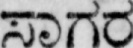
ಸಾಗರ
